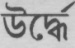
উৰ্দ্ধে
